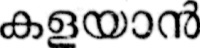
കളയാന്‍
